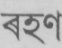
ৰহণ
